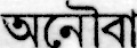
অনৌবা
